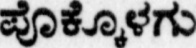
ಪೊಕ್ಕೊಳಗು
